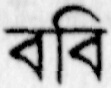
ববি
